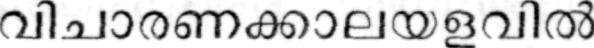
വിചാരണക്കാലയളവില്‍
